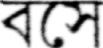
বসে
